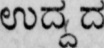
ಉದ್ದದ
